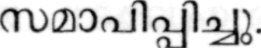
സമാപിപ്പിച്ചു.
